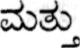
ಮತ್ತು
